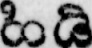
ಹಿಡಿ
